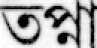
তপ্না
